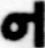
ન
